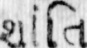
શાંતિ
